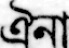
ঐনা
